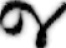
જ
